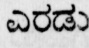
ಎರಡು
